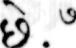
છે.૭
